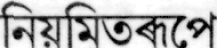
নিয়মিতৰূপে
